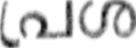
പ്രശ
